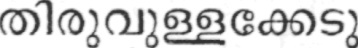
തിരുവുള്ളക്കേടു
